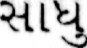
સાધુ
